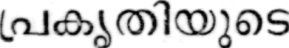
പ്രകൃതിയുടെ
